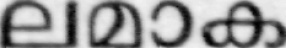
ലമാക
